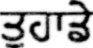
ਤੁਹਾਡੇ
